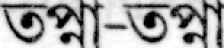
তপ্না-তপ্না
